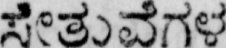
ಸೇತುವೆಗಳ
